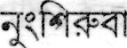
নুংশিরুবা
